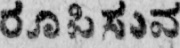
ರೂಪಿಸುವ
